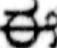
ಈ
